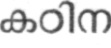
കഠിന
